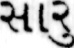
સારુ
